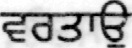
ਵਰਤਾਉ
